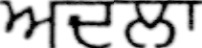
ਅਦਲਾ
